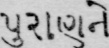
પુરાણને
